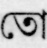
তো
